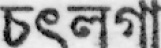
চৎলগা
